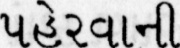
પહેરવાની
